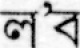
ল'ব
